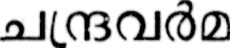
ചന്ദ്രവര്‍മ
